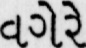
વગેરે
